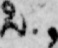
ಸಿ.,
